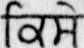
ਕਿਸੇ
